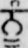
ਨੂੰ
